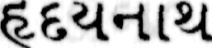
હૃદયનાથ
